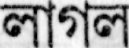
লাগল
